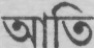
আতি
